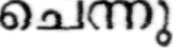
ചെന്നു
